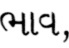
ભાવ,
